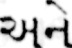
અને
